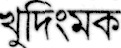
খুদিংমক
